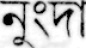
নুংদা
